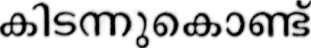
കിടന്നുകൊണ്ട്
